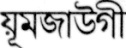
য়ূমজাউগী
